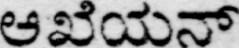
ಅಖೆಯನ್
